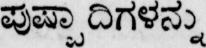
ಪುಷ್ಪಾದಿಗಳನ್ನು
